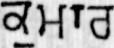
ਕੁਮਾਰ
